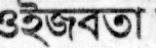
ওইজবতা
